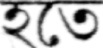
হতে
